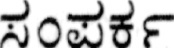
ಸಂಪರ್ಕ
